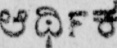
ಆರ್ಥಿಕ
